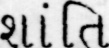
શાંતિ
